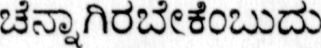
ಚೆನ್ನಾಗಿರಬೇಕೆಂಬುದು
